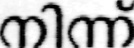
നിന്ന്
